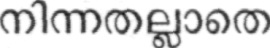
നിന്നതല്ലാതെ
